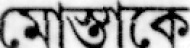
মোস্তাকে
